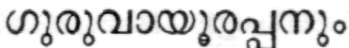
ഗുരുവായൂരപ്പനും
